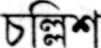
চল্লিশ
